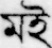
মই
